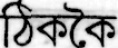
ঠিককৈ
